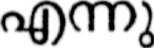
എന്നു
